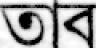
তাব
